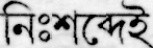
নিঃশব্দেই
